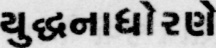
યુદ્ધનાધોરણે
